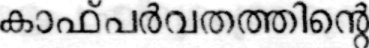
കാഫ്പര്‍വതത്തിന്റെ
